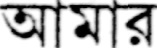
আমার
